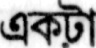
একটা
